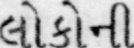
લોકોની
